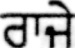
ਰਾਜੇ
